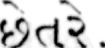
છેતરે.
